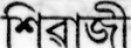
শিৱাজী
